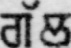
ਗੱਲ
